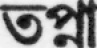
তপ্না
